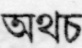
অথচ
